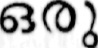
ഒരു
